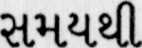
સમયથી
